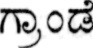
ಗ್ರಾಂಡೆ
